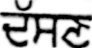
ਦੱਸਣ
